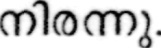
നിരന്നു.
